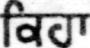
ਕਿਹਾ
